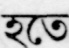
হতে
